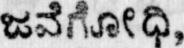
ಜವೆಗೋಧಿ,
